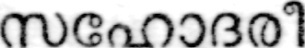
സഹോദരീ
